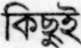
কিছুই
